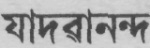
যাদৱানন্দ
